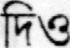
দিও
